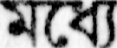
মধ্যে
